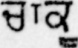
ਚਾਕੂ
